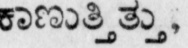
ಕಾಣುತ್ತಿತ್ತು,
